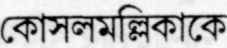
কোসলমল্লিকাকে
